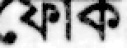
ফোক
